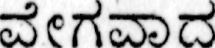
ವೇಗವಾದ
